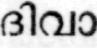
ദിവാ
